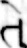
તે
